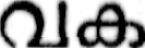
വക
